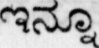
ಇನ್ನೂ
